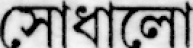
সোধালো
